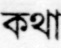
কথা
